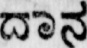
ದಾನ
